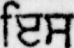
ਇਸ
